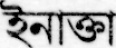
ইনাক্তা
